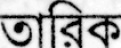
তারিক
